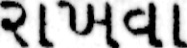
રાખવા
